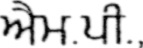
ਐਮ.ਪੀ.,
